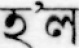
হ'ল
